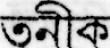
তনীক
